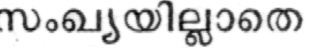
സംഖ്യയില്ലാതെ
